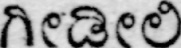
ಗೀಡೀಲಿ
